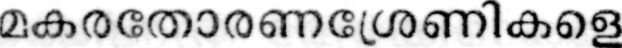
മകരതോരണശ്രേണികളെ
